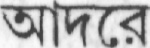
আদরে
